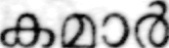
കമാര്‍
